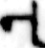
ન
